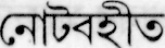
নোটবহীত
